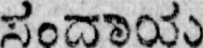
ಸಂದಾಯ
